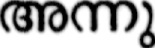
അന്നു
